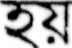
হয়
